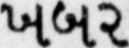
ખબર
